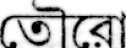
তৌরো
